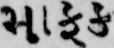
માફક
